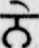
ਨੇ
